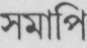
সমাপি
